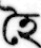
হৈ
